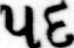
પદ
